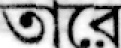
তারে
